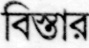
বিস্তার
